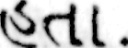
હતા.
